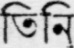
তিনি
